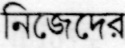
নিজেদের
